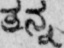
ತನ್ನ
